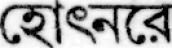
হোৎনরে
